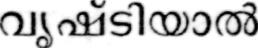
വൃഷ്ടിയാല്‍
